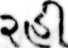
રહી
